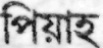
পিয়াহ
